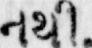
નથી.
